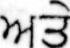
ਅਤੇ
